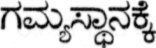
ಗಮ್ಯಸ್ಥಾನಕ್ಕೆ
